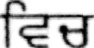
ਵਿਚ
